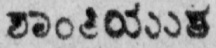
ಶಾಂತಿಯುತ
